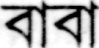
বাবা
